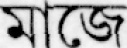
মাজে
